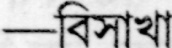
–বিসাখা
